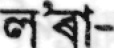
ল'ৰা-
